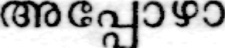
അപ്പോഴാ
